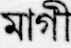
মাগী
